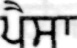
ਪੈਸਾ
